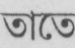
তাতে
